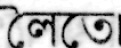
লৈতে।
